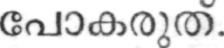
പോകരുത്.
